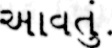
આવતું.
